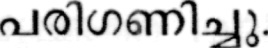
പരിഗണിച്ചു.
